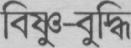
বিষ্ণু-বুদ্ধি
